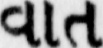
વાત
